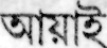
আয়াই
